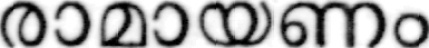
രാമായണം
